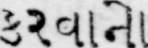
કરવાનો
